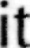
it
